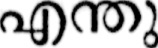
എന്തു
